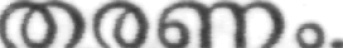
തരണം.
